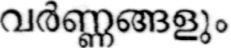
വര്‍ണ്ണങ്ങളും
